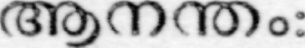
ആനന്തം:
